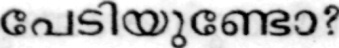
പേടിയുണ്ടോ?
